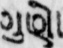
ગુણો
